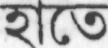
হাতে
